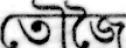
তৌজে
